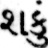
શકું
